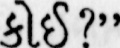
કોઈ?"
